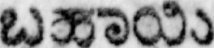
ಬಹಾಯಿ
